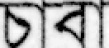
চাবা
